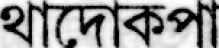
থাদোকপা
